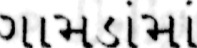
ગામડાંમાં
